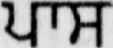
ਪਾਸ
